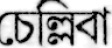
চেল্লিবা
